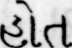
હોત
